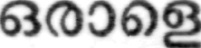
ഒരാളെ
